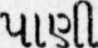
પાણી
